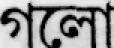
গলো
